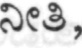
ನೀತಿ,
